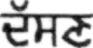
ਦੱਸਣ
